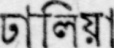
ঢালিয়া
